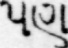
પણ
